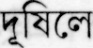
দূষিলে
